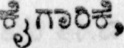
ಕೈಗಾರಿಕೆ,
